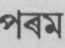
পৰম
